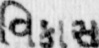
વિકાસ
